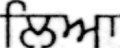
ਲਿਆ
